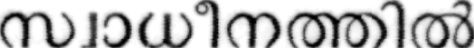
സ്വാധീനത്തില്‍
